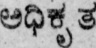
ಅಧಿಕೃತ
